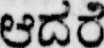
ಆದರೆ
